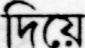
দিয়ে
